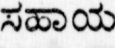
ಸಹಾಯ
